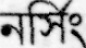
নর্সিং
